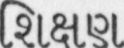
શિક્ષણ
